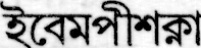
ইবেমপীশক্না
